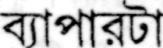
ব্যাপারটা
